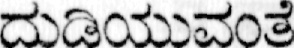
ದುಡಿಯುವಂತೆ
